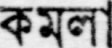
কমলা
